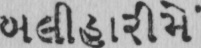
બલીહારીમેં
